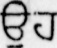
ਉਹ
